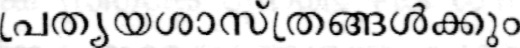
പ്രത്യയശാസ്ത്രങ്ങള്‍ക്കും
